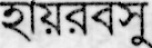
হায়রবসু
